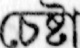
চেষ্টা
